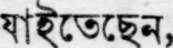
যাইতেছেন,
